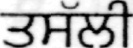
ਤਸੱਲੀ
